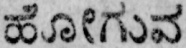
ಹೋಗುವ
